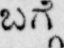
ಬಗ್ಗೆ
